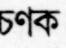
চণক
